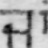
ਜਾਂ
